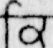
ਕਿ
